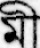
মী
